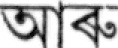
আৰু
